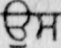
ਉਸ
